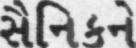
સૈનિકને
